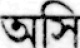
অসি
